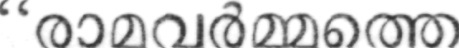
"രാമവര്‍മ്മത്തെ
